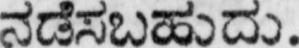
ನಡೆಸಬಹುದು.
